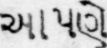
આપણે
